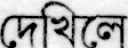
দেখিলে
